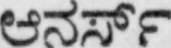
ಆನರ್ಸ್
